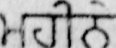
ਮਹੀਨੇ
